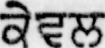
ਕੇਵਲ
